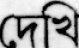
দেখি
